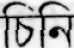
চিনি
